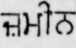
ਜ਼ਮੀਨ
